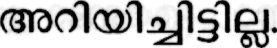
അറിയിച്ചിട്ടില്ല.
